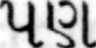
પણ
